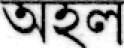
অহল
